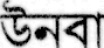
উনবা
